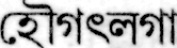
হৌগৎলগা
